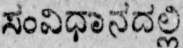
ಸಂವಿಧಾನದಲ್ಲಿ
